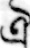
ঐ
